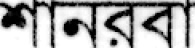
শানরবা
